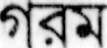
গরম
